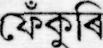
ফেঁকুৰি
